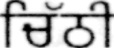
ਚਿੱਠੀ
